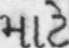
માટે
